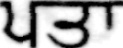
ਪਤਾ
